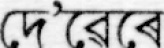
দে'ৱেৰে
